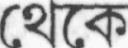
থেকে
